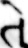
તે
